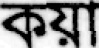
কয়া
